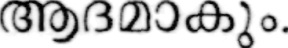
ആദമാകും.
